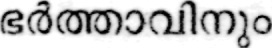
ഭര്‍ത്താവിനും
